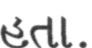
હતા.
